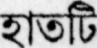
হাতটি
